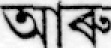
আৰু
